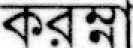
করম্না
